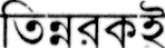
তিন্নরকই
